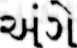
અંગે
